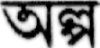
অল্প
